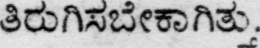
ತಿರುಗಿಸಬೇಕಾಗಿತ್ತು.
